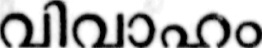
വിവാഹം
